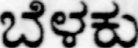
ಬೆಳಕು
